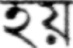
হয়
